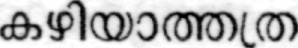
കഴിയാത്തത്ര
